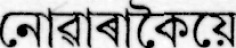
নোৱাৰাকৈয়ে
